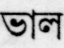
ভাল
